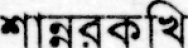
শান্নরকখি
